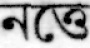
নত্তে
